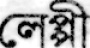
লেপ্পী
